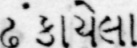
ઢંકાયેલા
